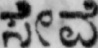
ಸೇವೆ
